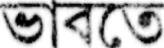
ভাবতে
